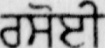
ਰਸੋਈ
